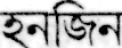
হনজিন
